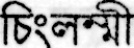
চিংলম্মী
